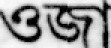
ওজা
